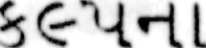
કલ્પના
